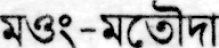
মওং-মতৌদা
